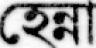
হেন্না
